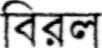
বিরল
